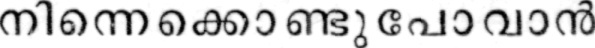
നിന്നെക്കൊണ്ടുപോവാന്‍
